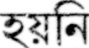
হয়নি
